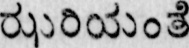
ಝರಿಯಂತೆ
